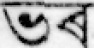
ভৰ
